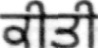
ਕੀਤੀ
